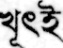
খূৎই
